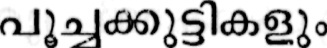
പൂച്ചക്കുട്ടികളും
